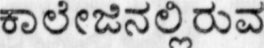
ಕಾಲೇಜಿನಲ್ಲಿರುವ
